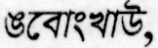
ঙবোংখাউ,
